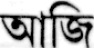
আজি
